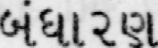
બંધારણ
